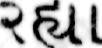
રહ્યા
